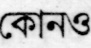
কোনও
